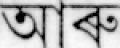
আৰু
